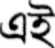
এই
